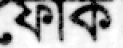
ফোক
